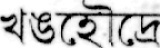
খঙহৌদ্রে
